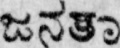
ಜನತಾ
